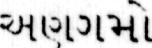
અણગમો
